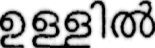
ഉള്ളില്‍
